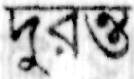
দুরন্ত
